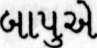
બાપુએ
